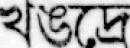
খঙদ্রে
